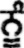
ਨੂੰ
